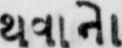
થવાનો
